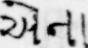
એના
